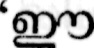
‘ഈ
